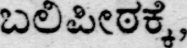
ಬಲಿಪೀಠಕ್ಕೆ,
